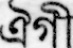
ঐগী
